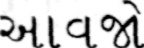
આવજો
